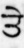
ਤੇ
